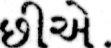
છીએ.
